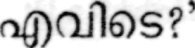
എവിടെ?’
